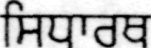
ਸਿਧਾਰਥ
